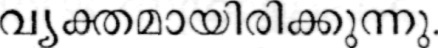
വ്യക്തമായിരിക്കുന്നു.
